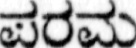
ಪರಮ
